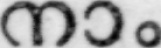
നാം
